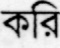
করি
